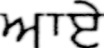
ਆਏ
